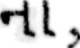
ના,
